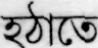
হঠাতে
